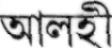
আলহী
